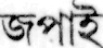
জপাই
